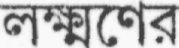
লক্ষ্মণের
